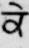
ਕੇ
